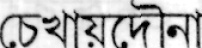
চেখায়দৌনা
